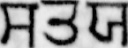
ਸਤਯ
